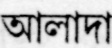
আলাদা
